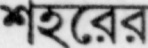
শহরের
